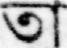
তা
